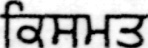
ਕਿਸਮਤ
